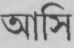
আসি
